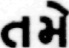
તમે
